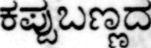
ಕಪ್ಪುಬಣ್ಣದ
